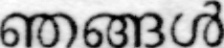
ഞങ്ങള്‍
